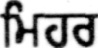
ਮਿਹਰ
